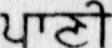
ਪਾਣੀ
